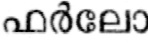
ഫര്‍ലോ
